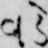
વડે
